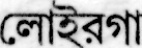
লোইরগা
